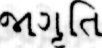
જાગૃતિ
